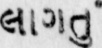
લાગતું
